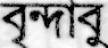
বৃন্দাবু
